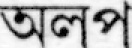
অলপ
